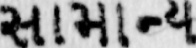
સામાન્ય
